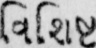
વિશિષ્ટ
